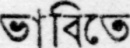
ভাবিতে
